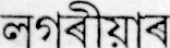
লগৰীয়াৰ
